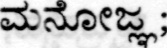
ಮನೋಜ್ಞ;
